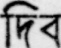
দিব
